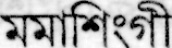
মমাশিংগী
